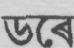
ডৰে
